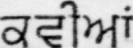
ਕਵੀਆਂ
